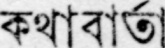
কথাবার্তা
